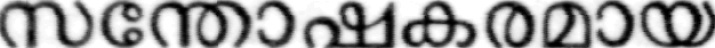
സന്തോഷകരമായ
